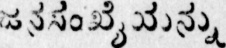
ಜನಸಂಖ್ಯೆಯನ್ನು
